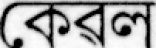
কেৱল
